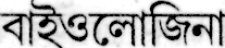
বাইওলোজিনা
